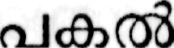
പകല്‍
